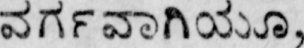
ವರ್ಗವಾಗಿಯೂ,
